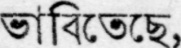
ভাবিতেছে,
